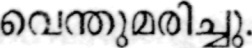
വെന്തുമരിച്ചു.
